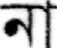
না
